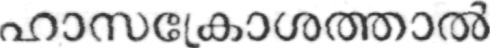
ഹാസക്രോശത്താല്‍
